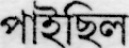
পাইছিল
